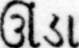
ઊંડા
